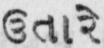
ઉતારે
